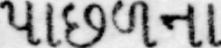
પાછળના
